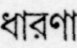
ধারণা
